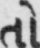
તો
